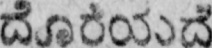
ದೊರೆಯದೆ
